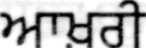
ਆਖ਼ਰੀ
